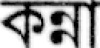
কন্না
